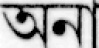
অনা
